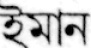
ইমান
